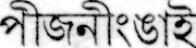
পীজনীংঙাই
